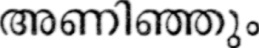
അണിഞ്ഞും
